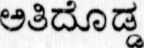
ಅತಿದೊಡ್ಡ
